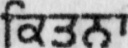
ਕਿਤਨਾ
